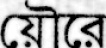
য়ৌরে
